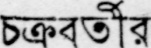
চক্রবর্তীর
